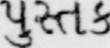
પુસ્તક
